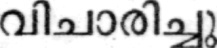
വിചാരിച്ചു
